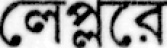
লেপ্লরে
